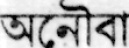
অনৌবা
